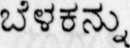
ಬೆಳಕನ್ನು
